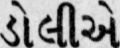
ડોલીએ
